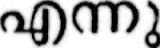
എന്നു
